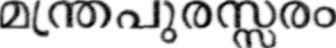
മന്ത്രപുരസ്സരം
